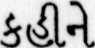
કહીને
